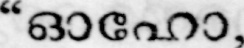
"ഓഹോ,
